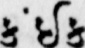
કંઈક
